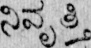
ನಿವೃತ್ತಿ
